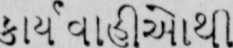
કાર્યવાહીઓથી
